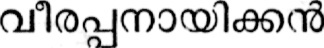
വീരപ്പനായിക്കന്‍
